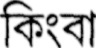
কিংবা
